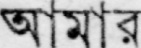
আমার
